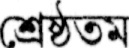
শ্রেষ্ঠতম
